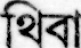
থিবা
